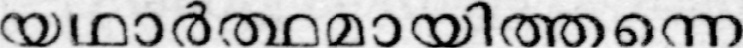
യഥാര്‍ത്ഥമായിത്തന്നെ
